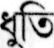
ধুতি
